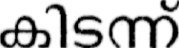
കിടന്ന്
